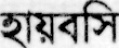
হায়বসি
